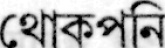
থোকপনি
